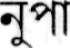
নুপা
